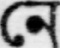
নে
